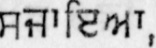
ਸਜਾਇਆ,
